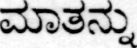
ಮಾತನ್ನು
